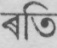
ৰতি
